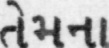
તેમના
